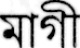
মাগী
